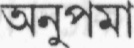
অনুপমা
